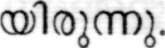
യിരുന്നു.
